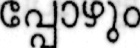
പ്പോഴും
